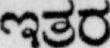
ಇತರ
